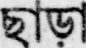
ছাড়া
